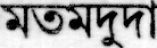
মতমদুদা
